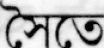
সৈতে
